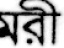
মরী
